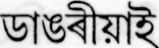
ডাঙৰীয়াই
